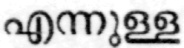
എന്നുള്ള
